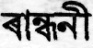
ৰান্ধনী
